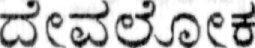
ದೇವಲೋಕ
